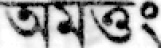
অমত্তং
